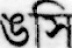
ঙসি
